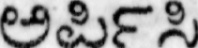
ಅರ್ಪಿಸಿ
